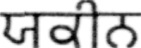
ਯਕੀਨ
